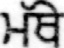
ਮੱਥੇ
